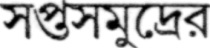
সপ্তসমুদ্রের
